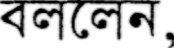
বললেন,
